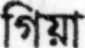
গিয়া
